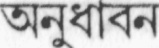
অনুধাবন
